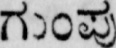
ಗುಂಪು
